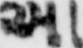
આ
